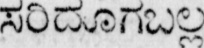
ಸರಿದೂಗಬಲ್ಲ
